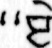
''ਏ
